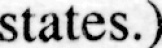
states.)
